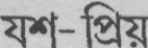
যশ-প্ৰিয়
